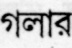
গলার
